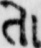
તો
